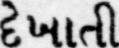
દેખાતી
